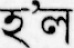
হ'ল
